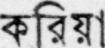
করিয়া
